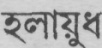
হলায়ুধ
